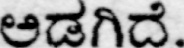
ಅಡಗಿದೆ.
